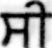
ਸੀ
